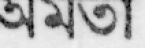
অমতা
